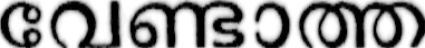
വേണ്ടാത്ത
